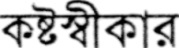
কষ্টস্বীকার
